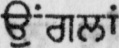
ਉਂਗਲਾਂ
